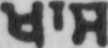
ਖਾਸ
